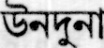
উনদুনা
